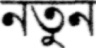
নতুন
